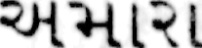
અમારા
